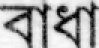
বাধা
